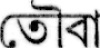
তৌবা
